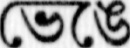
ভেঙে
